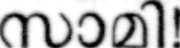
സാമി!
